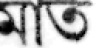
মাত
